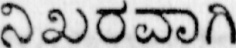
ನಿಖರವಾಗಿ
